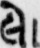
લો
